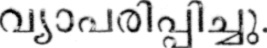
വ്യാപരിപ്പിച്ചു.
